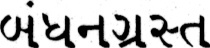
બંધનગ્રસ્ત
